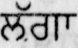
ਲੱਗਾ
